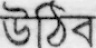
উঠিব
